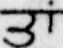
ਤਾਂ
